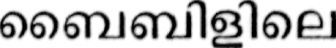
ബൈബിളിലെ
